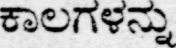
ಕಾಲಗಳನ್ನು
